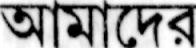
আমাদের
